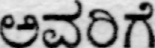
ಅವರಿಗೆ
